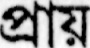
প্রায়
